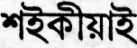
শইকীয়াই
